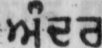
ਅੰਦਰ
